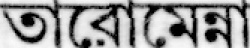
তারোমেন্না
